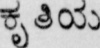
ಕೃತಿಯ
